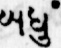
બધું
